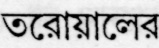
তরোয়ালের
